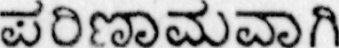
ಪರಿಣಾಮವಾಗಿ
